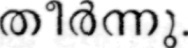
തീര്‍ന്നു.
